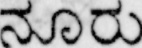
ನೂರು
